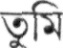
তুমি
